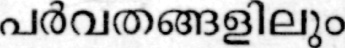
പര്‍വതങ്ങളിലും
